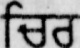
ਚਿਰ
